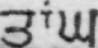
ਤਾਂਘ
